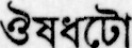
ঔষধটো
